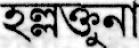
হল্লক্তুনা
